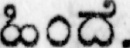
ಹಿಂದೆ,
